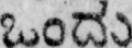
ಒಂದು
